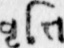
વૃત્તિ
